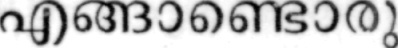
എങ്ങാണ്ടൊരു
